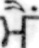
ਮੈਂ
